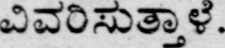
ವಿವರಿಸುತ್ತಾಳೆ.
